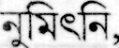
নুমিৎনি,
